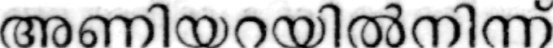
അണിയറയില്‍നിന്ന്
